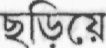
ছড়িয়ে
